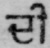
ਦੀ
